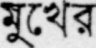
মুখের
